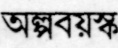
অল্পবয়স্ক
